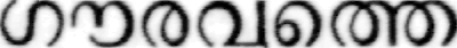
ഗൌരവത്തെ
